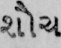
શૌચ
